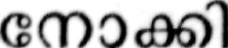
നോക്കി
